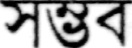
সম্ভব
